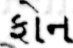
ફોન
